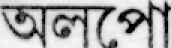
অলপো
